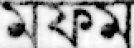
মফম
